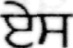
ਏਸ
